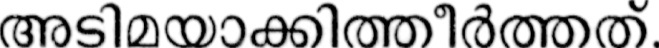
അടിമയാക്കിത്തീര്‍ത്തത്.
